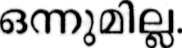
ഒന്നുമില്ല.
